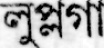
লুপ্লগা
